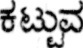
ಕಟ್ಟುವ
